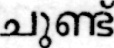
ചുണ്ട്
